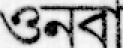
ওনবা
